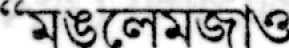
“মঙলেমজাও
